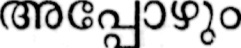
അപ്പോഴും
